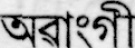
অৱাংগী
